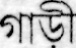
গাড়ী
